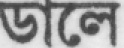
ডালে
